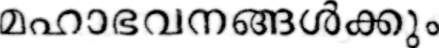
മഹാഭവനങ്ങള്‍ക്കും
